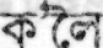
ক'লৈ
